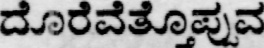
ದೊರೆವೆತ್ತೊಪ್ಪುವ
